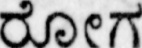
ರೋಗ
